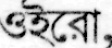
ওইরো,
